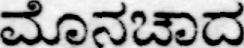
ಮೊನಚಾದ
